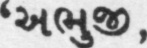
'અભુજી,
